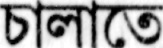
চালাতে
